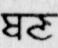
ਬਣ
